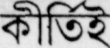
কীর্তিই
